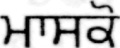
ਮਾਸਕੋ
